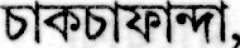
চাকচাফান্দা,
